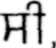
ਸੀ,
